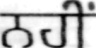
ਨਹੀਂ
